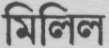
মিলিল
